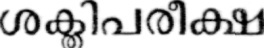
ശക്തിപരീക്ഷ
